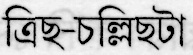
ত্রিছ-চল্লিছটা
